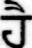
ਹੈ
